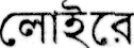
লোইরে
